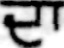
ਦਾ
